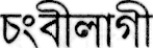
চংবীলাগী
